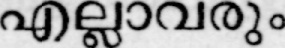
എല്ലാവരും
